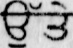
ਉੱਤੇ
